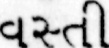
વસ્તી
